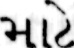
માટે
